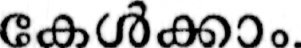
കേള്‍ക്കാം.
